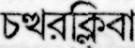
চত্থরক্লিবা
